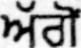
ਅੱਗੋਂ
